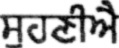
ਸੁਹਣੀਐ
